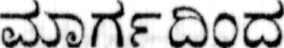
ಮಾರ್ಗದಿಂದ
